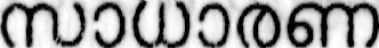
സാധാരണ
